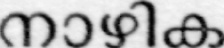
നാഴിക
